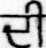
ਦੀ
